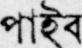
পাইব
